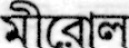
মীরোল
